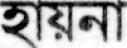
হায়না
